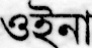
ওইনা
